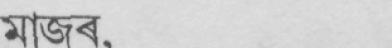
মাজৰ,
